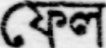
ফেল
